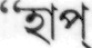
"হাপ্
